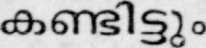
കണ്ടിട്ടും
